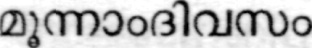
മൂന്നാംദിവസം
